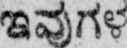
ಇವುಗಳ
